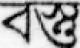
বস্তু
